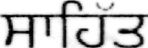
ਸਾਹਿੱਤ
